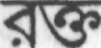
রক্ত
